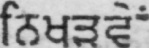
ਨਿਖੜਵੇਂ
